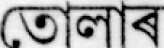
তোলাৰ
